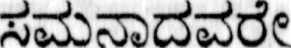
ಸಮನಾದವರೇ
